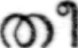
തീ
